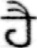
ਹੈ
